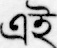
এই
